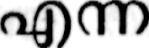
എന്ന
